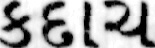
કદાચ
